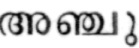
അഞ്ചു
